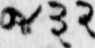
જરૂર
